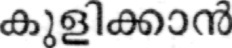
കുളിക്കാന്‍
